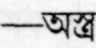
–অস্ত্র
